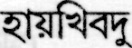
হায়খিবদু
